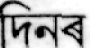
দিনৰ
